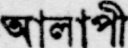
আলাপী
